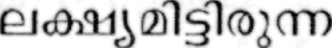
ലക്ഷ്യമിട്ടിരുന്ന
